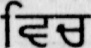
ਵਿਚ
